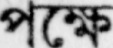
পক্ষে
